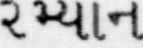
રમ્યાન
